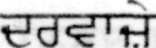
ਦਰਵਾਜ਼ੇ
